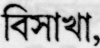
বিসাখা,
